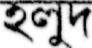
হলুদ
